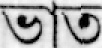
ভাত
